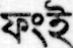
ফংই
